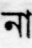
না
